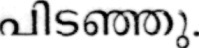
പിടഞ്ഞു.
